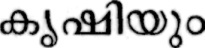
കൃഷിയും
